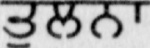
ਤੁਲਨਾ
